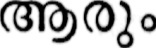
ആരും
